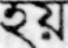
হয়
